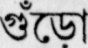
গুঁড়ো
